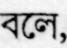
বলে,
